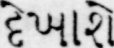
દેખાશે
